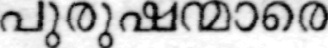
പുരുഷന്മാരെ
